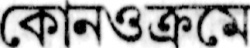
কোনওক্রমে
